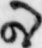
જે
